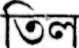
তিল
